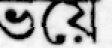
ভয়ে
